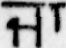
ਜਾ
